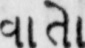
વાતો
